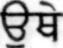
ਉਥੇ
